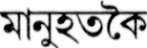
মানুহতকৈ
